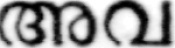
അവ
